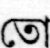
তো
